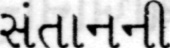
સંતાનની
